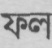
ফল
